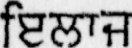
ਇਲਾਜ
